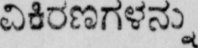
ವಿಕಿರಣಗಳನ್ನು
